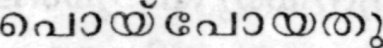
പൊയ്പോയതു
